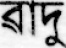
ৱাদু
